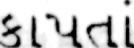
કાપતાં
